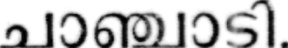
ചാഞ്ചാടി.
